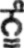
ਨੂੰ
